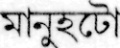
মানুহটো
